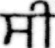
ਸੀ
